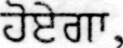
ਹੋਏਗਾ,
